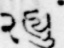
રહ્યું
